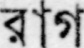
রাগ
